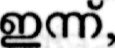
ഇന്ന്,
